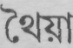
থৈয়া
